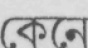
কেনে
